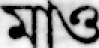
মাও
